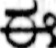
ಈ
